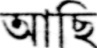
আছি
